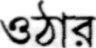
ওঠার
